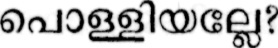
പൊള്ളിയല്ലേ?
